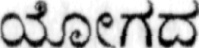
ಯೋಗದ
